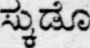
ಸ್ಕುಡೊ
